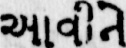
આવીને
